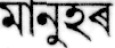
মানুহৰ
